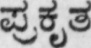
ಪ್ರಕೃತ
